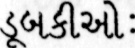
ડૂબકીઓઃ
